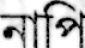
নাপি
